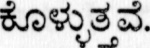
ಕೊಳ್ಳುತ್ತವೆ.
